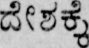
ದೇಶಕ್ಕೆ
